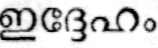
ഇദ്ദേഹം
